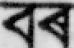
বৰ
